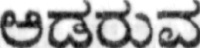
ಅಡರುವ
